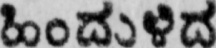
ಹಿಂದುಳಿದ
